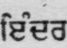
ਇੰਦਰ
